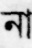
না
